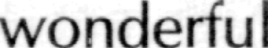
wonderful
